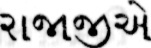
રાજાજીએ
